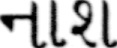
નાશ
